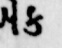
એક
